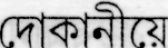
দোকানীয়ে
